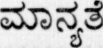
ಮಾನ್ಯತೆ
